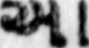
આ
